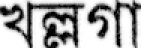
খল্লগা
